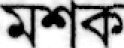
মশক
